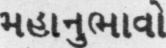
મહાનુભાવો
